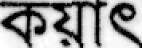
কয়া
